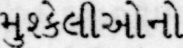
મુશ્કેલીઓનો
